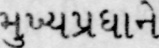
મુખ્યપ્રધાને
